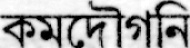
কমদৌগনি
